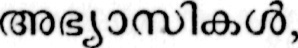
അഭ്യാസികള്‍,
